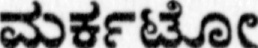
ಮರ್ಕಟೋ
